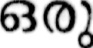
ഒരു
